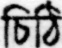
চিঠি
